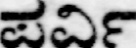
ಪರ್ವಿ
